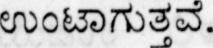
ಉಂಟಾಗುತ್ತವೆ.
